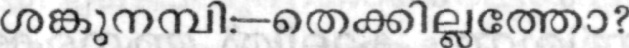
ശങ്കുനമ്പി:-തെക്കില്ലത്തോ?
